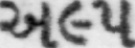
અલ્પ
